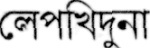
লেপখিদুনা
